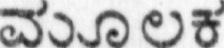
ಮೂಲಕ
